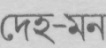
দেহ-মন
